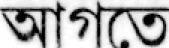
আগতে
